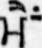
ਮੈਂ
